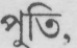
পুতি,
